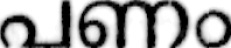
പണം
